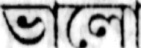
ভালো
